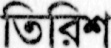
তিরিশ
